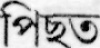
পিছত
